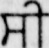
ਸੀ
